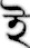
ই
